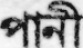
পানী
